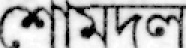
শোমদল
